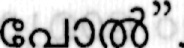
പോല്‍"
